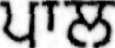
ਪਾਲ
